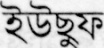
ইউছুফ
